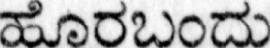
ಹೊರಬಂದು
